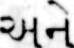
અને
